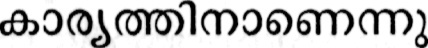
കാര്യത്തിനാണെന്നു
